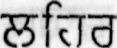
ਲਹਿਰ
